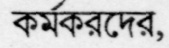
কর্মকরদের,
